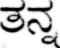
ತನ್ನ
